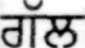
ਗੱਲ
